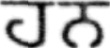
ਹਨ
